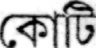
কোটি
